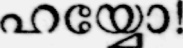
ഹയ്യോ!
